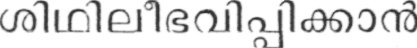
ശിഥിലീഭവിപ്പിക്കാന്‍
